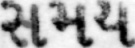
સમય
